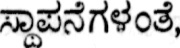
ಸ್ಥಾಪನೆಗಳಂತೆ,
